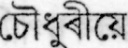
চৌধুৰীয়ে
